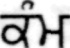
ਕੰਮ
